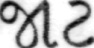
જાટ
